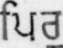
ਪਿਰੁ
